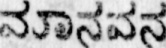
ಮಾನವನ
